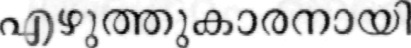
എഴുത്തുകാരനായി
